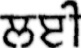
ਲਈ
